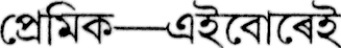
প্রেমিক-এইবোৰেই
